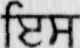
ਇਸ
